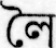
লৈ
